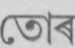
তোৰ
